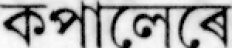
কপালেৰে
